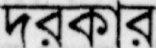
দরকার
